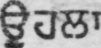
ਉਹਲਾ
